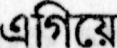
এগিয়ে
